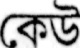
কেউ
